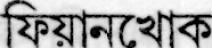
ফিয়ানখোক
